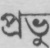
প্ৰভু
